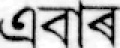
এবাৰ
